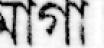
মাগা
